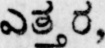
ಎತ್ತರ,
